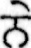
ਨੇ
